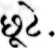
છૂટે.
